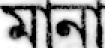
মানা
